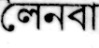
লৈনবা
